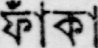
ফাঁকা
